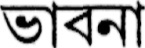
ভাবনা
